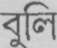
বুলি
